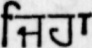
ਜਿਹਾ
